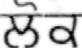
ਲੋਕ
